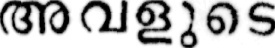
അവളുടെ
